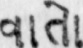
વાતો
